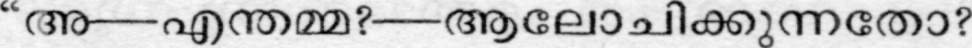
"അ-എന്തമ്മ?-ആലോചിക്കുന്നതോ?
